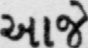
આજે
